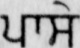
ਪਾਸੇ
